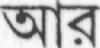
আর
